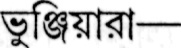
ভুঞ্জিয়ারা-
